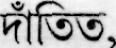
দাঁতিত,
